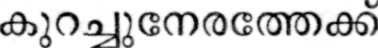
കുറച്ചുനേരത്തേക്ക്
